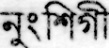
নুংশিগী
